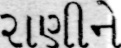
રાણીને
